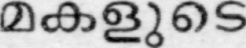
മകളുടെ
